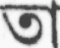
তা
